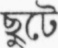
ছুটে
